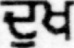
ਦੁਖ
